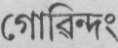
গোৱিন্দং
